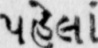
પહેલાં
